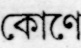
কোণে
